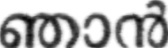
ഞാന്‍
